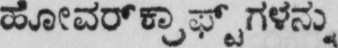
ಹೋವರ್‌ಕ್ರಾಫ್ಟ್‌ಗಳನ್ನು
